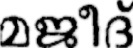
മജീദ്
